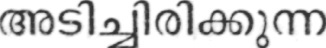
അടിച്ചിരിക്കുന്ന
